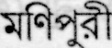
মণিপুরী
